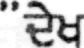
''ਦੇਖ
